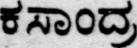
ಕಸಾಂದ್ರ
